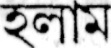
হলাম
